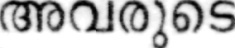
അവരുടെ
